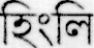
হিংলি
